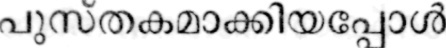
പുസ്തകമാക്കിയപ്പോള്‍
